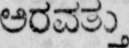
ಅರವತ್ತು
